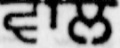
ਵਾਲ
